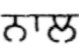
ਨਾਲ
